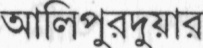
আলিপুরদুয়ার
